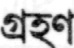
গ্রহণ
